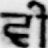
ਵੀ
